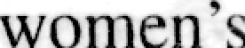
women's
